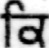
ਕਿ
